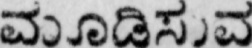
ಮೂಡಿಸುವ
